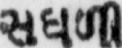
સધળી
